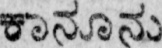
ಕಾನೂನು
